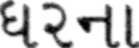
ધરના
